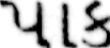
પાક
